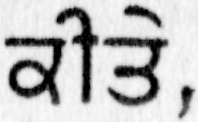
ਕੀਤੇ,
